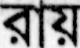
রায়
